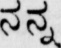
ನನ್ನ
